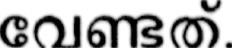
വേണ്ടത്.
